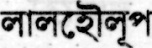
লালহৌলুপ
